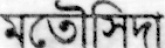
মতৌসিদা
